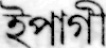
ইপাগী
